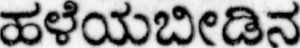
ಹಳೆಯಬೀಡಿನ
